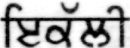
ਇਕੱਲੀ
